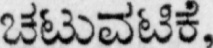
ಚಟುವಟಿಕೆ,
